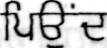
ਪਿਉਂਦ
